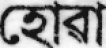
হোৱা
